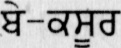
ਬੇ-ਕਸੂਰ
